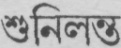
শুনিলন্ত
